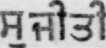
ਸੁਜੀਤੀ
